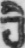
ਹੈ
